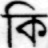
কি
